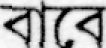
বাবে
